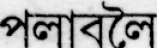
পলাবলৈ
